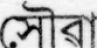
সৌৱা
